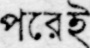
পরেই
